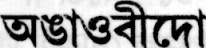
অঙাওবীদো
